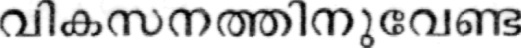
വികസനത്തിനുവേണ്ട
